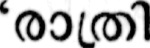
‘രാത്രി
